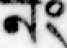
নং
